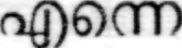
എന്നെ
